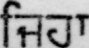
ਜਿਹਾ
